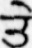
ਤੇ
